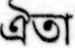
ঐতা
